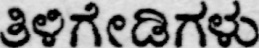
ತಿಳಿಗೇಡಿಗಳು
